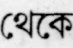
থেকে
